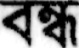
বন্ধ
